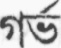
গর্ভ
